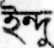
ইন্দু
